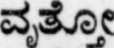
ವೃತ್ತೋ
